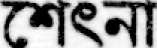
শেৎনা
